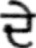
ਦੇ
